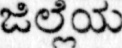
ಜಿಲ್ಲೆಯ
